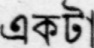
একটা
